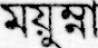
ময়ুম্না
